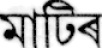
মাটিৰ
